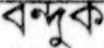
বন্দুক
